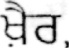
ਖ਼ੈਰ,
